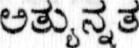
ಅತ್ಯುನ್ನತ
